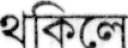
থকিলে
